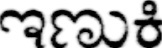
ಇಣುಕಿ
